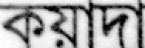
কয়াদা
